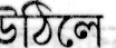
উঠিলে
